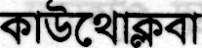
কাউথোক্লবা
